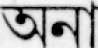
অনা
